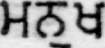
ਮਨੁਖ
